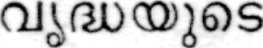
വൃദ്ധയുടെ
